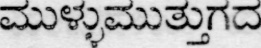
ಮುಳ್ಳುಮುತ್ತುಗದ
